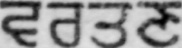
ਵਰਤਣ
